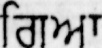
ਗਿਆ
